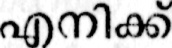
എനിക്ക്
